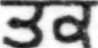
ਤਕ
